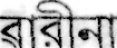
ৱারীনা
